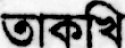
তাকখি
